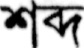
শব্দ
